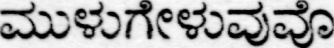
ಮುಳುಗೇಳುವುವೊ
